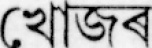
খোজৰ
